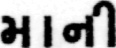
માની
